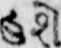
હશે
